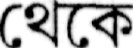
থেকে
